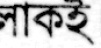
লাকই
